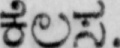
ಕೆಲಸ.
